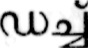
ഡച്ച്
